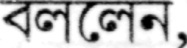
বললেন,
